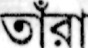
তাঁরা
